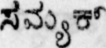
ಸಮ್ಯಕ್
